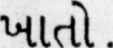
ખાતો.
